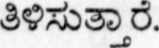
ತಿಳಿಸುತ್ತಾರೆ.
